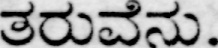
ತರುವೆನು.
